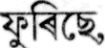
ফুৰিছে,
